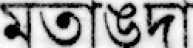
মতাঙদা
